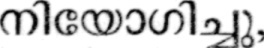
നിയോഗിച്ചു,
